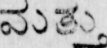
ಮತ್ತು
